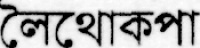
লৈথোকপা
